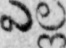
ಎಲ್ಲ
